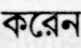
করেন
